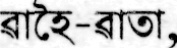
ৱাহৈ-ৱাতা,
